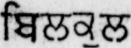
ਬਿਲਕੁਲ
